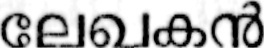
ലേഖകന്‍
